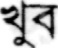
খুব
